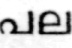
പല
